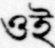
ওই
